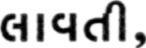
લાવતી,
